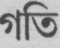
গতি
